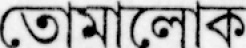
তোমালোক
